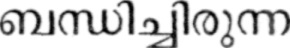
ബന്ധിച്ചിരുന്ന
